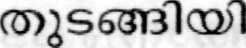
തുടങ്ങിയി
